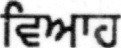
ਵਿਆਹ
